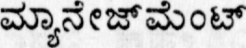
ಮ್ಯಾನೇಜ್‌ಮೆಂಟ್
